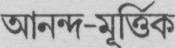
আনন্দ-মূৰ্ত্তিক
